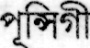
পূন্সিগী
